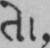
તો,
